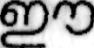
ഈ
